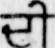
ਦੀ
